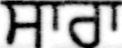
ਸਾਰਾ
